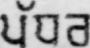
ਪੱਧਰ
